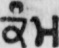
ਕੰਮ
